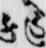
કહે
